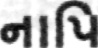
નાપિ
